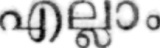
എല്ലാം
